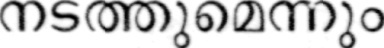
നടത്തുമെന്നും
